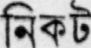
নিকট
